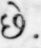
છે.
